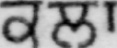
ਕਲਾ
